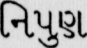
નિપુણ
